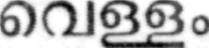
വെള്ളം
